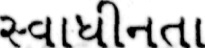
સ્વાધીનતા
